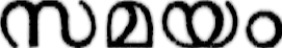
സമയം
